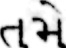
તમે
